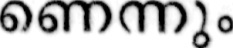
ണെന്നും
